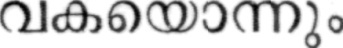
വകയൊന്നും
